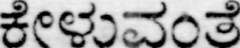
ಕೇಳುವಂತೆ
